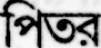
পিতর
